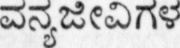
ವನ್ಯಜೀವಿಗಳ
